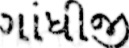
ગાંધીજી
